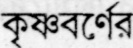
কৃষ্ণবর্ণের
